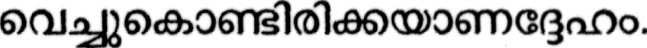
വെച്ചുകൊണ്ടിരിക്കയാണദ്ദേഹം.
